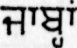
ਜਾਬ੍ਹਾਂ
